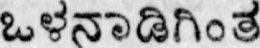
ಒಳನಾಡಿಗಿಂತ
